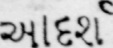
આદર્શ
